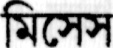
মিসেস
